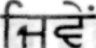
ਜਿਵੇਂ
